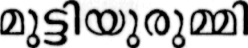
മുട്ടിയുരുമ്മി
